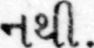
નથી.
